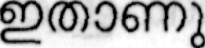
ഇതാണു
